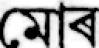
মোৰ
